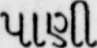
પાણી
